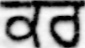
ਕਰ
